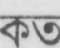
কত
